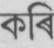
কৰি
